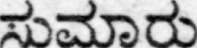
ಸುಮಾರು
